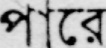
পারে
